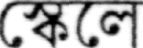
স্কেলে
